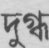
দুগ্ধ
